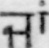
ਜਾਂ
